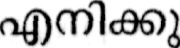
എനിക്കു
